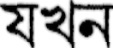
যখন
